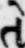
તે
